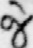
જે
